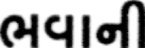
ભવાની
